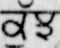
ਕੁੱਝ
